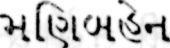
મણિબહેન
